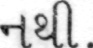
નથી.
